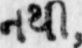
નથી,
